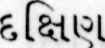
દક્ષિણ
